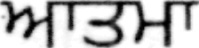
ਆਤਮਾ
